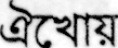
ঐখোয়
